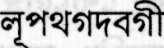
লূপথগদবগী
